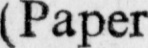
(Paper
